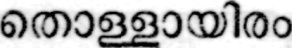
തൊള്ളായിരം
